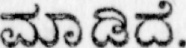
ಮಾಡಿದೆ.
